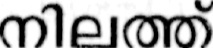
നിലത്ത്
